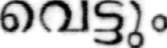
വെട്ടും
